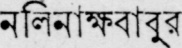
নলিনাক্ষবাবুর
